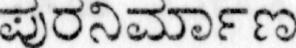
ಪುರನಿರ್ಮಾಣ
